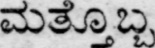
ಮತ್ತೊಬ್ಬ
